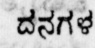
ದನಗಳ
